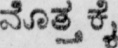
ಮೊತ್ತಕ್ಕೆ
